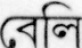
বেলি
